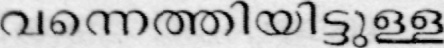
വന്നെത്തിയിട്ടുള്ള
